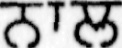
ਨਾਲ
